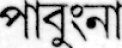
পাবুংনা
